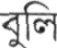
বুলি
